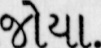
જોયા.
